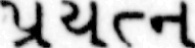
પ્રયત્ન
